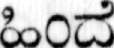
ಹಿಂದೆ
